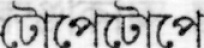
টোপেটোপে
